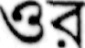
ওর
